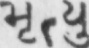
મૃત્યુ
